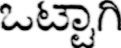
ಒಟ್ಟಾಗಿ
